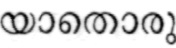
യാതൊരു
